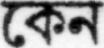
কেন
